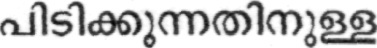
പിടിക്കുന്നതിനുള്ള
